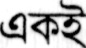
একই
